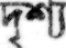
দৃশ্য
